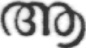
ആ
